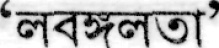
‘লবঙ্গলতা’
